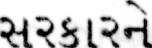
સરકારને
